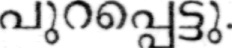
പുറപ്പെട്ടു.
